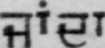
ਜਾਂਦਾ
